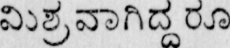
ಮಿಶ್ರವಾಗಿದ್ದರೂ
